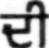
ਦੀ
